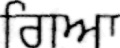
ਗਿਆ
